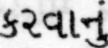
કરવાનું
